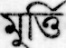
মুর্ত্তি
